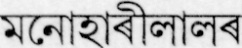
মনোহাৰীলালৰ
